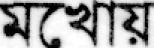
মখোয়
